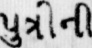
પુત્રીની
